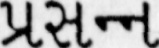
પ્રસન્ન
